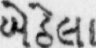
બેઠેલા
